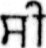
ਸੀ
